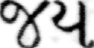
જય
